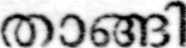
താങ്ങി
